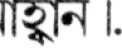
আহ্বান
